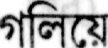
গলিয়ে
